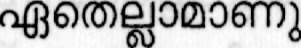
ഏതെല്ലാമാണു
